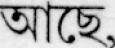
আছে,
